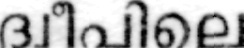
ദ്വീപിലെ
